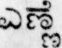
ಎಣ್ಣೆ
